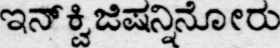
ಇನ್‌ಕ್ವಿಜಿಷನ್ನಿನೋರು
